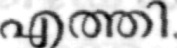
എത്തി.
